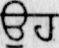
ਉਹ
